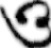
ও
